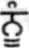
ਨੂੰ
